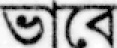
ভাবে
